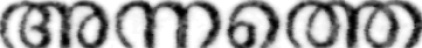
അന്നത്തെ
